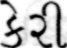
કેરી
